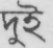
দুই
